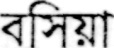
বসিয়া
